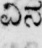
ವಿನ
